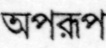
অপরূপ
